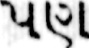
પણ
